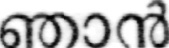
ഞാന്‍
